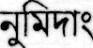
নুমিদাং
